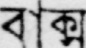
বাক্স
